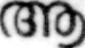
ആ
